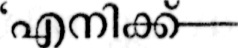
‘എനിക്ക്-
